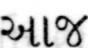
આજ
